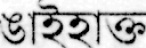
ঙাইহাক্ত
